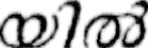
യില്‍
